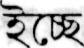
ইচ্ছে
